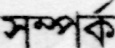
সম্পর্ক
